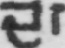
ਦਾ
